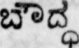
ಬೌದ್ಧ
